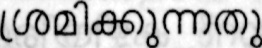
ശ്രമിക്കുന്നതു
